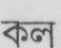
কল
